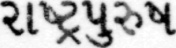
રાષ્ટ્રપુરુષ
